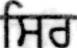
ਸਿਰ
